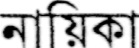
নায়িকা
